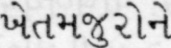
ખેતમજુરોને
